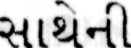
સાથેની
